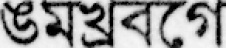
ঙমখ্রবগে
